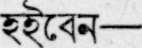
হইবেন—
